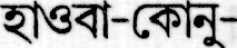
হাওবা-কোনু-
